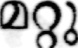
മറ്റു
